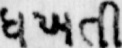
ધખતી
